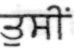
ਤੁਸੀਂ
